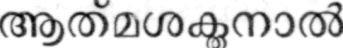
ആത്മശക്തനാല്‍
